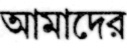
আমাদের
